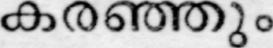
കരഞ്ഞും
